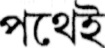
পথেই
